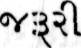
જરૂરી
